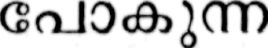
പോകുന്ന
